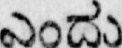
ಎಂದು
